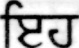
ਇਹ
